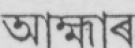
আহ্মাৰ
